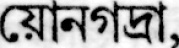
য়োনগদ্রা,
